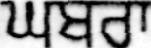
ਘਬਰਾ
